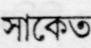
সাকেত
